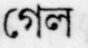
গেল
